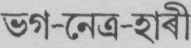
ভগ-নেত্ৰ-হাৰী
